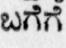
ಬಗೆಗೆ
